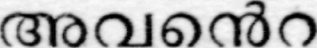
അവന്റെ
